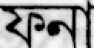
ফনা
